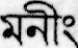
মনীং
